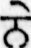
ਨੇ
